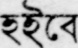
হইবে
